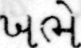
ખભે
